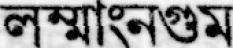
লম্মাংনগুম
